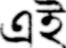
এই
